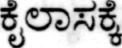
ಕೈಲಾಸಕ್ಕೆ
